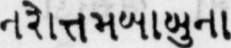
નરોત્તમબાબુના
